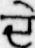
ਦੇ
